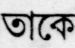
তাকে
